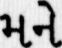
મને
